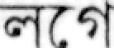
লগে
